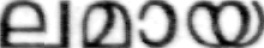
ലമായ
